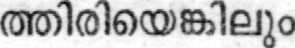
ത്തിരിയെങ്കിലും
